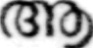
ആ
